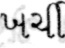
ખર્ચી
